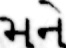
મને
